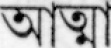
আত্মা
